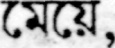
মেয়ে,
